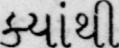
ક્યાંથી
